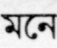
মনে
